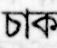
চাক
